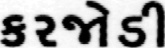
કરજોડી
